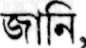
জানি,
